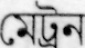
মেট্রন
